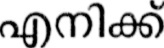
എനിക്ക്
